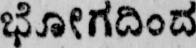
ಭೋಗದಿಂದ
